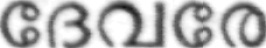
ദേവരേ
